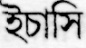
ইচাসি
